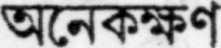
অনেকক্ষণ
